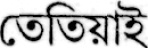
তেতিয়াই
